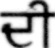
ਦੀ
